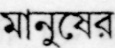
মানুষের
